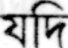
যদি
